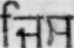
ਜਿਸ
